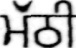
ਮੱਠੀ
